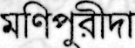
মণিপুরীদা
